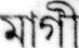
মাগী
